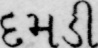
દમડી
